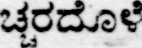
ಚ್ಚರದೊಳೆ
